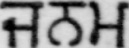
ਜਨਮ
